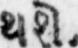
થશે.
